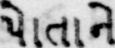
પોતાને
